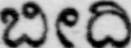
ಬೀದಿ
